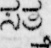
ಸತ್ತ
